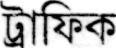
ট্রাফিক
